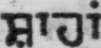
ਸ਼ਾਹਾਂ
